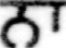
ਨਾ
